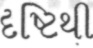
દૃષ્ટિથી
